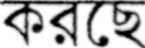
করছে
